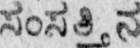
ಸಂಸತ್ತಿನ
